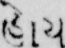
હોય
